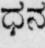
ಧನ
